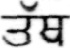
ਤੱਥ
